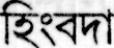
হিংবদা
